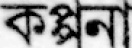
কপ্পনা
